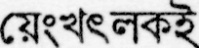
য়েংখৎলকই
